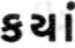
ક્યાં
